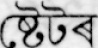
ষ্টেটৰ
